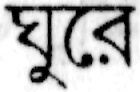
ঘুরে
